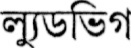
ল্যুডভিগ
